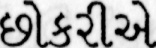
છોકરીએ
